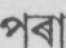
পৰা
